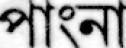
পাংনা
